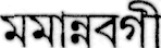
মমান্নবগী
